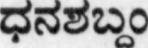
ಧನಶಬ್ದಂ
